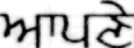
ਆਪਣੇ
